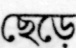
ছেড়ে
